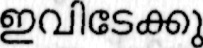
ഇവിടേക്കു
